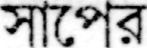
সাপের
